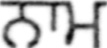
ਨਾਮ
